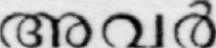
അവര്‍
